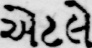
એટલે
